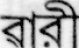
ৱারী
